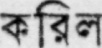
করিল
